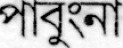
পাবুংনা
